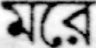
মরে
